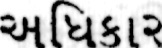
અધિકાર
